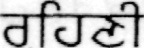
ਰਹਿਣੀ
